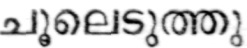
ചൂലെടുത്തു
